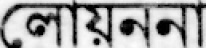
লোয়ননা
